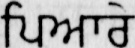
ਪਿਆਰੇ
